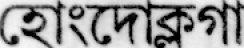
হোংদোক্লগা
